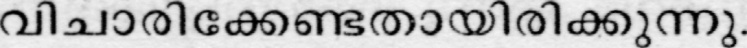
വിചാരിക്കേണ്ടതായിരിക്കുന്നു.
